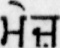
ਮੇਜ਼
